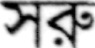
সরু
